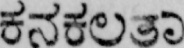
ಕನಕಲತಾ
